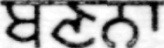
ਬਣਨਾ
